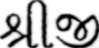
શ્રીજી
